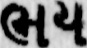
ભય
